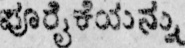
ಪೂರೈಕೆಯನ್ನು
